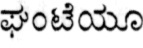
ಘಂಟೆಯೂ
